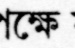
পক্ষে
